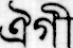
ঐগী
